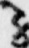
કે
